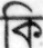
কি
